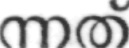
ന്നത്
